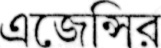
এজেন্সির
